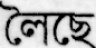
লৈছে
